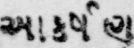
આકર્ષણ
